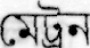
মেট্রন
